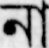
না
